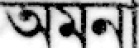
অমনা
